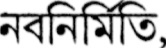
নবনির্মিতি,
